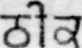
ਠੀਕ
